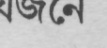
যজনে
